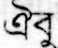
ঐবু
